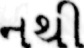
નથી
